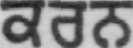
ਕਰਨ
